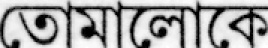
তোমালোকে
